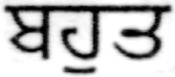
ਬਹੁਤ
